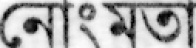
নোংমতা
